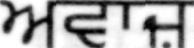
ਅਵਾਜ਼
